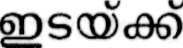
ഇടയ്ക്ക്
